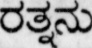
ರತ್ನನು
